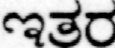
ಇತರ
